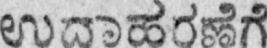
ಉದಾಹರಣೆಗೆ
